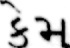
કેમ
